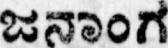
ಜನಾಂಗ
